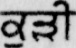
ਕੁੜੀ
